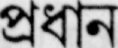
প্রধান
